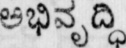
ಅಭಿವೃದ್ಧಿ
